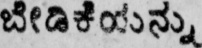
ಬೇಡಿಕೆಯನ್ನು
